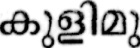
കുളിമു
